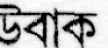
উবাক
